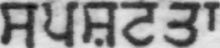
ਸਪਸ਼ਟਤਾ
